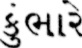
કુંભારે
